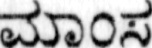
ಮಾಂಸ
